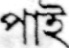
পাই
